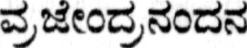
ವ್ರಜೇಂದ್ರನಂದನ
